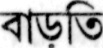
বাড়তি
